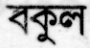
বকুল
